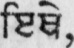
ਇਥੇ,
